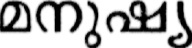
മനുഷ്യ
